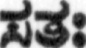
ಸತಃ
